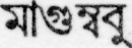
মাগুম্ববু
